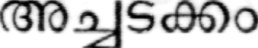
അച്ചടക്കം
